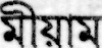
মীয়াম
